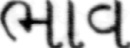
ભાવ
